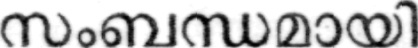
സംബന്ധമായി
